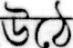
উঠে
